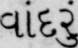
વાંદરું
